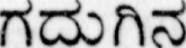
ಗದುಗಿನ
